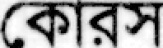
কোরস
